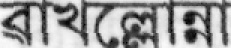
ৱাখল্লোন্না
